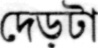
দেড়টা
